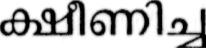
ക്ഷീണിച്ച
